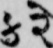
કરે
